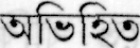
অভিহিত
